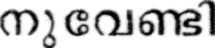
നുവേണ്ടി
